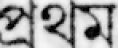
প্রথম
